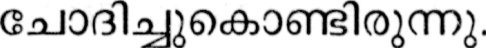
ചോദിച്ചുകൊണ്ടിരുന്നു.
